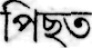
পিছত
